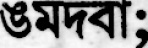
ঙমদবা;
